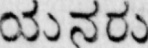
ಯನರು
